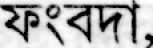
ফংবদা,
